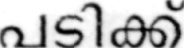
പടിക്ക്
